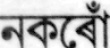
নকৰোঁ
